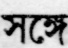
সঙ্গে
